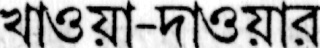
খাওয়া-দাওয়ার
